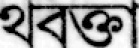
থবক্তা
